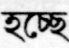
হচ্ছে
